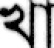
খা
